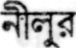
নীলুর
